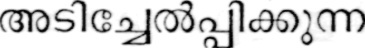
അടിച്ചേല്‍പ്പിക്കുന്ന
